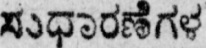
ಸುಧಾರಣೆಗಳ
